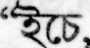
“ইচে,
